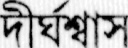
দীর্ঘশ্বাস
